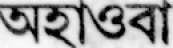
অহাওবা
